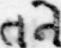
તને
